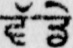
ਵੱਡੇ
